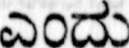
ಎಂದು
